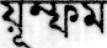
য়ূম্ফম
